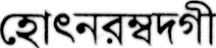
হোৎনরম্বদগী
